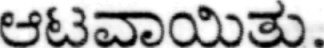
ಆಟವಾಯಿತು.
